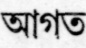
আগত
